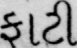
ફાટી
